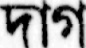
দাগ
